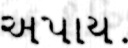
અપાય.
